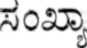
ಸಂಖ್ಯಾ
